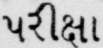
પરીક્ષા
